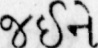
જઈને
